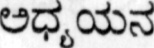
ಅಧ್ಯಯನ
